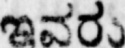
ಇವರು
